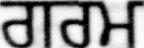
ਗਰਮ
